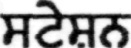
ਸਟੇਸ਼ਨ
